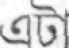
এটা
